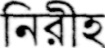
নিরীহ
